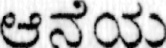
ಆನೆಯ
